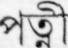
পত্নী
